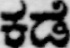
ಕಡೆ
